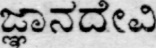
ಜ್ಞಾನದೇವಿ
